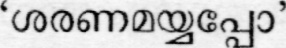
'ശരണമയ്യപ്പോ’
